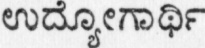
ಉದ್ಯೋಗಾರ್ಥಿ
